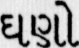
ઘણો
